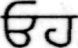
ਓਹ
